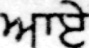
ਆਏ
